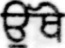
ਉੱਥੇ
